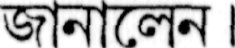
জানালেন।
